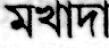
মখাদা
